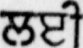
ਲਈ
